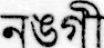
নঙগী
